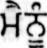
ਮੈਨੂੰ
